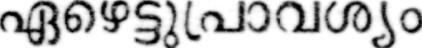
ഏഴെട്ടുപ്രാവശ്യം
